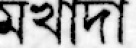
মখাদা
